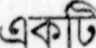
একটি
